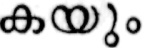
കയും
